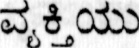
ವ್ಯಕ್ತಿಯು
